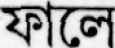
ফালে
